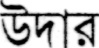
উদার
